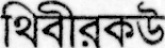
থিবীরকউ
